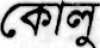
কোলু
